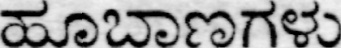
ಹೂಬಾಣಗಳು
